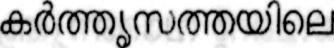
കര്‍ത്തൃസത്തയിലെ
